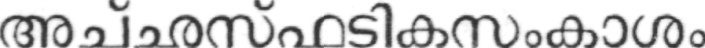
അച്ഛസ്ഫടികസംകാശം
